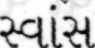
સ્વાંસ
